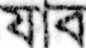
যাব
